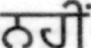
ਨਹੀਂ
